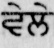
ਵੇਲੇ
